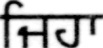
ਜਿਹਾ
